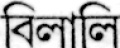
বিলালি
